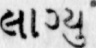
લાગ્યું
